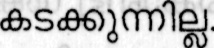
കടക്കുന്നില്ല.
